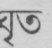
ঘৃত
